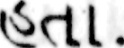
હતા.
